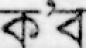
ক'ব
